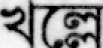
খল্লে
